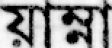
য়াম্না
